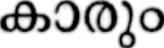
കാരും
